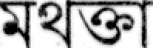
মথক্তা
